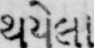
થયેલા
